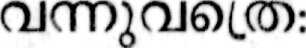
വന്നുവത്രെ:
